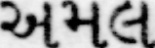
અમલ
